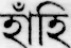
হাঁহি
